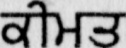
ਕੀਮਤ
